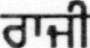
ਰਾਜੀ
